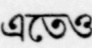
এতেও
